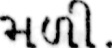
મળી.
